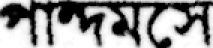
পান্দমসে
